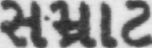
સમ્રાટ
